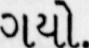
ગયો.
